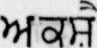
ਅਕਸ਼ੈ
